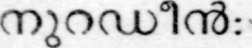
നുറഡീന്‍:
